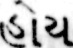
હોય
